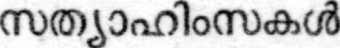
സത്യാഹിംസകള്‍
